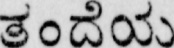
ತಂದೆಯ
